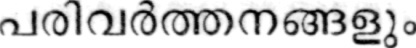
പരിവര്‍ത്തനങ്ങളും
